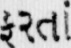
ફરતાં
